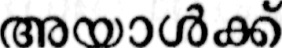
അയാള്‍ക്ക്
